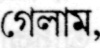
গেলাম,
